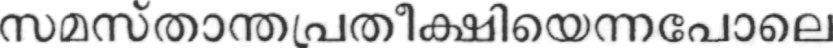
സമസ്താന്തപ്രതീക്ഷിയെന്നപോലെ
